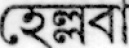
হেল্লবা
